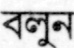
বলুন
